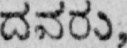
ದವರು,
